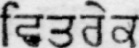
ਵਿਤਰੇਕ
